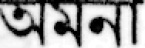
অমনা
